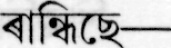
ৰান্ধিছে-
